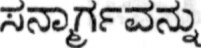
ಸನ್ಮಾರ್ಗವನ್ನು
